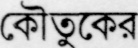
কৌতুকের
